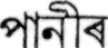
পানীৰ
